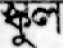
স্কুল
